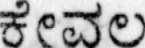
ಕೇವಲ
